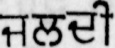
ਜਲਦੀ
